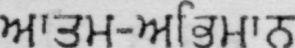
ਆਤਮ-ਅਭਿਮਾਨ
